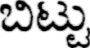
ಬಿಟ್ಟು
